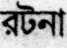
রটনা
